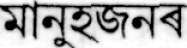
মানুহজনৰ
